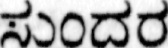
ಸುಂದರ
